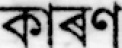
কাৰণ
